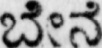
ಬೇನೆ
